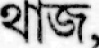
থাজ,
